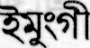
ইমুংগী
